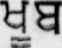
ਖੂਬ
